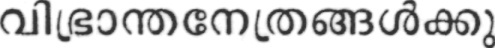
വിഭ്രാന്തനേത്രങ്ങള്‍ക്കു
